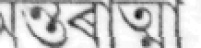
অন্তৰাত্মা
